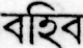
বহিব
